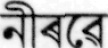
নীৰৱে
